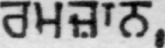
ਰਮਜ਼ਾਨ,
